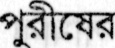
পুরীষের
